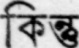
কিন্তু
